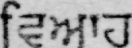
ਵਿਆਹ
